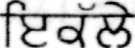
ਇਕੱਲੇ
